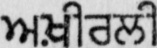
ਅਖ਼ੀਰਲੀ
